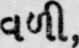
વળી,
